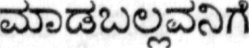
ಮಾಡಬಲ್ಲವನಿಗೆ
